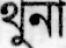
থুনা
